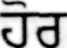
ਹੋਰ
